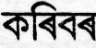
কৰিবৰ
